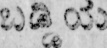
ಬಡ್ಡಿಯ
